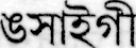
ঙসাইগী
